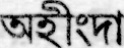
অহীংদা
